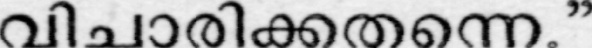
വിചാരിക്കതന്നെ."
